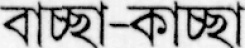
বাচ্ছা-কাচ্ছা
